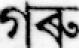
গৰু
